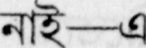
নাই-এ
